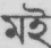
মই
